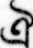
ঐ
